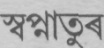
স্বপ্নাতুৰ
